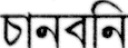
চানবনি
